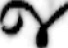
જ
